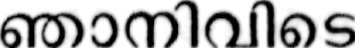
ഞാനിവിടെ
